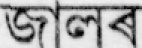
জালৰ
